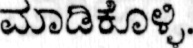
ಮಾಡಿಕೊಳ್ಳಿ.
